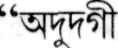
“অদুদগী
